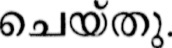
ചെയ്തു.
